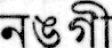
নঙগী
